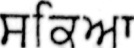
ਸਕਿਆ
